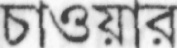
চাওয়ার
